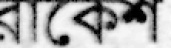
রাকেশ
